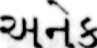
અનેક
